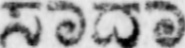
ಸಾದಾ
